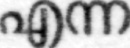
എന്ന
